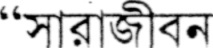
“সারাজীবন
